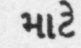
માટે
